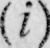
(i)
